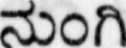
ನುಂಗಿ
